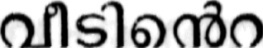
വീടിന്റെ
